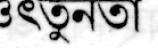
ওৎতুনতা
